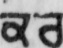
ਕਰ
